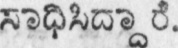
ಸಾಧಿಸಿದ್ದಾರೆ.
